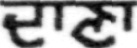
ਦਾਣਾ
